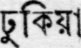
ঢুকিয়া
